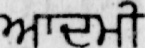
ਆਦਮੀ
